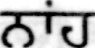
ਨਾਂਹ
